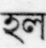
হল
